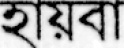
হায়বা
